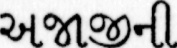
અજાજીની
